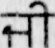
ਜੀ
